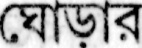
ঘোড়ার
